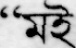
"মই
